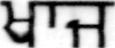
ਖਾਜ
